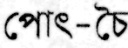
পোৎ-চৈ
